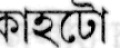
কাহটো
